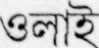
ওলাই
